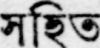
সহিত
